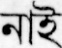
নাই
